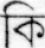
কি
